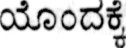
ಯೊಂದಕ್ಕೆ
